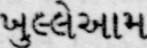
ખુલ્લેઆમ
